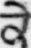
ਕੇ
